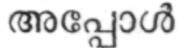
അപ്പോള്‍
